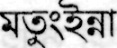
মতুংইন্না
